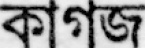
কাগজ
